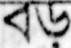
বড়
